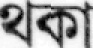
থকা
